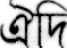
ঐদি
